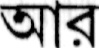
আর
